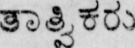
ತಾತ್ವಿಕರು
